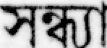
সন্ধ্যা
